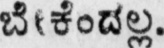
ಬೇಕೆಂದಲ್ಲ.
